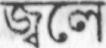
জ্বলে
